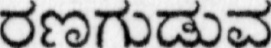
ರಣಗುಡುವ
